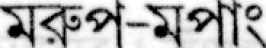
মরুপ-মপাং
